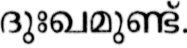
ദുഃഖമുണ്ട്.
